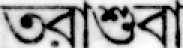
তরাশুবা
